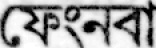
ফেংনবা
